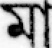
মা
